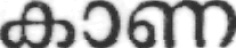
കാണ
